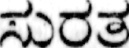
ಸುರತ
